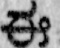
ಈ
